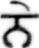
ਨੇ
